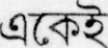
একেই
